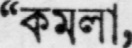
‘‘কমলা,
